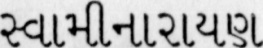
સ્વામીનારાયણ
